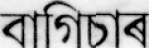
বাগিচাৰ
